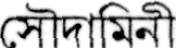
সৌদামিনী
